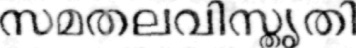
സമതലവിസ്തൃതി
